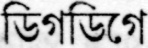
ডিগডিগে
